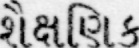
શૈક્ષણિક
